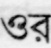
ওর
